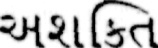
અશક્તિ
